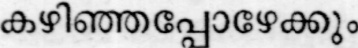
കഴിഞ്ഞപ്പോഴേക്കും
